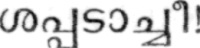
ശപ്പടാച്ചീ!
